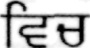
ਵਿਚ
